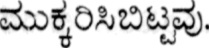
ಮುಕ್ಕರಿಸಿಬಿಟ್ಟವು.
